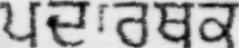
ਪਦਾਰਥਕ
